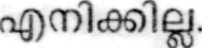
എനിക്കില്ല.
